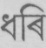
ধৰি
